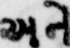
અને
